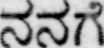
ನನಗೆ
